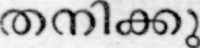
തനിക്കു
